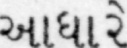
આધારે
